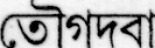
তৌগদবা
